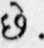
છે.
